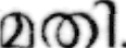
മതി.
